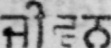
ਜੀਵਨ
